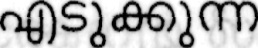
എടുക്കുന്ന
